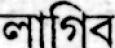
লাগিব
